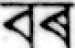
বৰ
